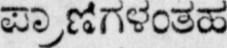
ಪ್ರಾಣಿಗಳಂತಹ
